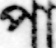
পা
